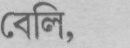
বেলি,
